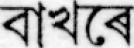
বাখৰে
